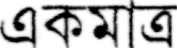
একমাত্র
